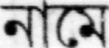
নামে
